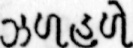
ઝળહળે
